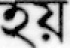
হয়
